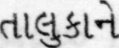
તાલુકાને
